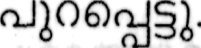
പുറപ്പെട്ടു.
